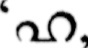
'ഹ,
